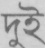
দুই
